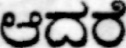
ಆದರೆ
